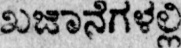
ಖಜಾನೆಗಳಲ್ಲಿ
